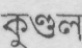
কুণ্ডল
